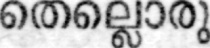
തെല്ലൊരു
